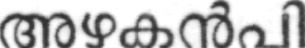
അഴകന്‍പി
